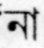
‘না
